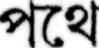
পথে
